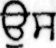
ਉਸ
